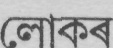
লোকৰ
